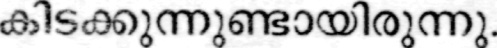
കിടക്കുന്നുണ്ടായിരുന്നു.
